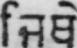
ਜਿਥੇ
